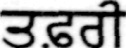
ਤਫ਼ਰੀ
